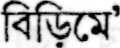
বিড়িমে’
